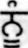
ਨੂੰ
